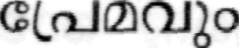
പ്രേമവും
